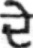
ਦੇ
